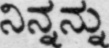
ನಿನ್ನನ್ನು
